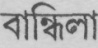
বান্ধিলা
